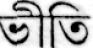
ভীতি
